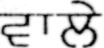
ਵਾਲੇ
